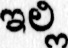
ಇಲ್ಲಿ
